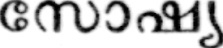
സോഷ്യ
